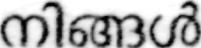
നിങ്ങള്‍
